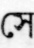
সে
